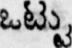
ಒಟ್ಟು
